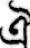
ঐ
